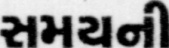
સમયની
